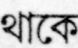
থাকে
